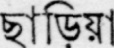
ছাড়িয়া
